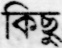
কিছু
